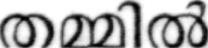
തമ്മില്‍
